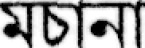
মচানা
